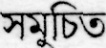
সমুচিত
